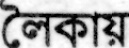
লৈকায়
